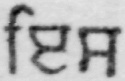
ਇਸ
